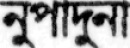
নুপাদুনা
